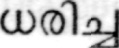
ധരിച്ച
